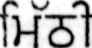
ਮਿੱਠੀ
